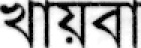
খায়বা
